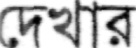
দেখার
